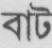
বাট
